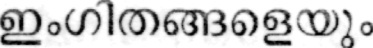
ഇംഗിതങ്ങളെയും
